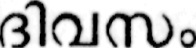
ദിവസം
